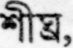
শীঘ্র,
